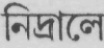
নিদ্ৰালে
